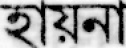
হায়না
